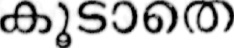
കൂടാതെ
